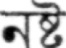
নষ্ট
